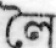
লৈ
